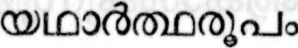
യഥാര്‍ത്ഥരൂപം
